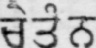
ਚੇਤੰਨ
